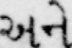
અને
